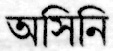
অসিনি
